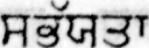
ਸਭੱਯਤਾ
